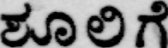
ಶೂಲಿಗೆ
